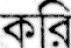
করি
